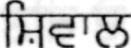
ਸ਼ਿਵਾਲ
